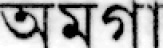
অমগা
